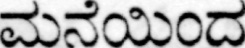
ಮನೆಯಿಂದ
